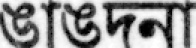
ঙাঙদনা
